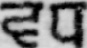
ਵਧ
